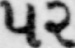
પર
